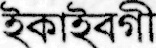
ইকাইবগী
